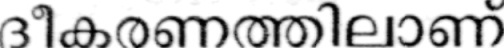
ദീകരണത്തിലാണ്
